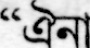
“ঐনা
